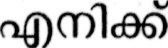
എനിക്ക്
